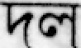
দল
